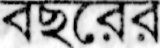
বছরের
